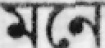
মনে
